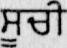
ਸੂਚੀ
